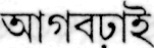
আগবঢ়াই
